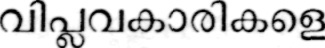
വിപ്ലവകാരികളെ
